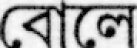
বোলে
